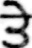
ਤੇ
